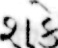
શકે
